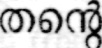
തന്റെ
